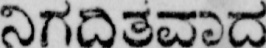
ನಿಗದಿತವಾದ
